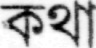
কথা
